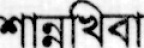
শান্নখিবা
